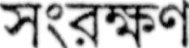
সংরক্ষণ
